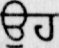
ਉਹ
